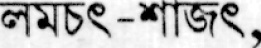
লমচৎ-শাজৎ,
